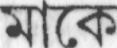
মাকে
